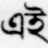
এই
